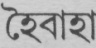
হৈবাহা
